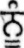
ਨੂੰ
